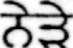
ਨੇੜੇ
